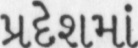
પ્રદેશમાં
